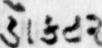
ડૉક્ટર
